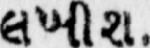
લખીશ.
